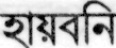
হায়বনি
